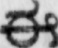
ಈ
